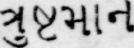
ત્રુષ્ટમાન
